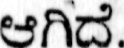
ಆಗಿದೆ.
